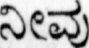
ನೀವು
